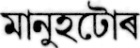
মানুহটোৰ
